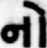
નો
